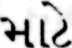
માટે
